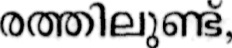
രത്തിലുണ്ട്,
